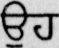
ਉਹ
